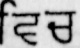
ਵਿਚ
